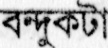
বন্দুকটা
